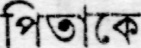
পিতাকে
